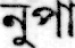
নুপা
